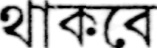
থাকবে
